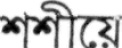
শশীয়ে
